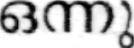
ഒന്നു
